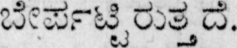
ಬೇರ್ಪಟ್ಟಿರುತ್ತದೆ.
